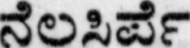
ನೆಲಸಿರ್ಪೆ
